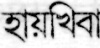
হায়খিবা
